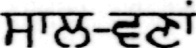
ਸਾਲ-ਵਣਾਂ
